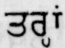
ਤਰ੍ਹਾਂ
